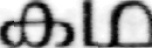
കഥ
